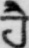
ਹੈ
